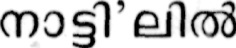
നാട്ടി’ലില്‍
